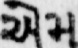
એમ
